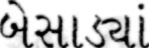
બેસાડ્યાં
